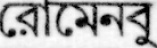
রোমেনবু
